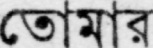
তোমার
